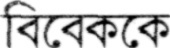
বিবেককে
